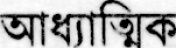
আধ্যাত্মিক
